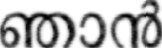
ഞാന്‍
